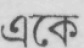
একে
